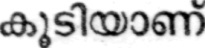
കൂടിയാണ്
